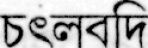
চৎলবদি
